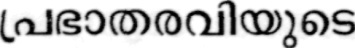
പ്രഭാതരവിയുടെ
